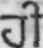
ਹੀ
